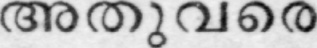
അതുവരെ
